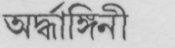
অৰ্দ্ধাঙ্গিনী
